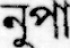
নুপা
